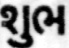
શુભ
